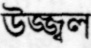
উজ্জ্বল
